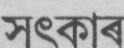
সৎকাৰ
